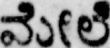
ಮೇಲೆ
